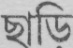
ছাড়ি
